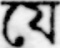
যে
